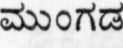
ಮುಂಗಡ
